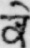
ਕੇ
